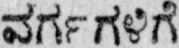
ವರ್ಗಗಳಿಗೆ
